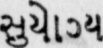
સુયોગ્ય
